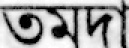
তমদা
